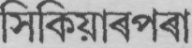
সিকিয়াৰপৰা
